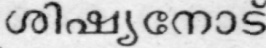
ശിഷ്യനോട്
